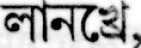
লানখ্রে,
